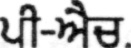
ਪੀ-ਐਚ.
